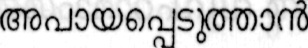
അപായപ്പെടുത്താന്‍
